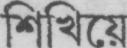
শিখিয়ে
